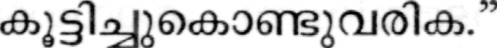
കൂട്ടിച്ചുകൊണ്ടുവരിക."
